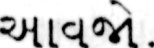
આવજો.
